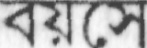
বয়সে
